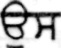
ਉਸ
